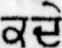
ਕਦੇ
